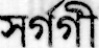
সর্গগী
